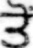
ਤੋਂ
